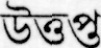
উত্তপ্ত
